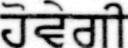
ਹੋਵੇਗੀ
